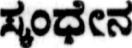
ಸ್ಕಂಧೇನ
